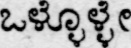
ಒಳ್ಳೊಳ್ಳೇ
